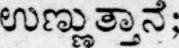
ಉಣ್ಣುತ್ತಾನೆ;
